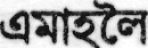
এমাহলৈ
